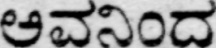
ಅವನಿಂದ
